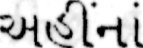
અહીંનાં
